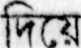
দিয়ে
